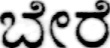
ಬೇರೆ
